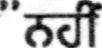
''ਨਹੀਂ
